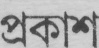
প্ৰকাশ
